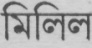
মিলিল
